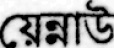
য়েন্নাউ
